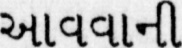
આવવાની
